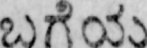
ಬಗೆಯ
